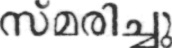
സ്മരിച്ചു
